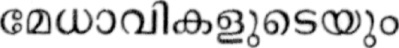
മേധാവികളുടെയും
